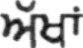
ਅੱਖਾਂ
